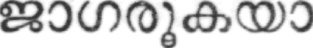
ജാഗരൂകയാ
